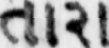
તારા
